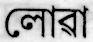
লোৱা
